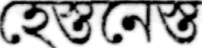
হেস্তনেস্ত
